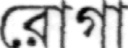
রোগা
